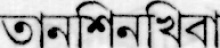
তানশিনখিবা
